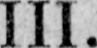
III.
